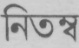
নিতম্ব
